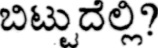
ಬಿಟ್ಟುದೆಲ್ಲಿ?
